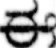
ಈ
